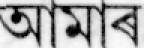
আমাৰ
